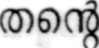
തന്റെ
